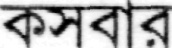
কসবার
